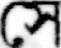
সে
